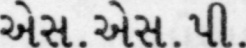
એસ.એસ.પી.
